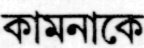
কামনাকে
